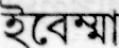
ইবেম্মা
